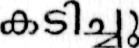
കടിച്ചു
